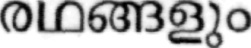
രഥങ്ങളും
